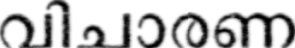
വിചാരണ
